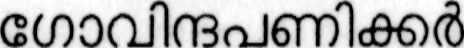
ഗോവിന്ദപണിക്കര്‍
